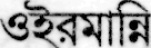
ওইরমান্নি
